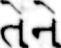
તેને
